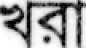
খরা
